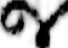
જ
